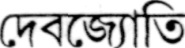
দেবজ্যোতি
